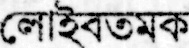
লোইবতমক
